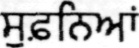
ਸੁਫ਼ਨਿਆਂ
